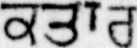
ਕਤਾਰ
